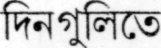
দিনগুলিতে
